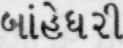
બાંહેધરી
